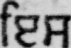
ਇਸ
